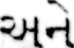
અને
